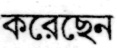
করেছেন
